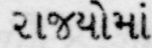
રાજ્યોમાં
